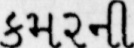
કમરની
